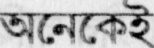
অনেকেই
